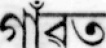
গাঁৱত
